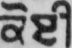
ਕੋਈ
